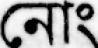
নোং
